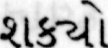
શક્યો
